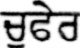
ਚੁਫੇਰ
